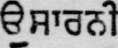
ਉਸਾਰਨੀ
